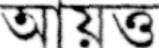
আয়ত্ত
